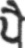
ਪੈ
